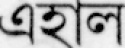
এহাল
